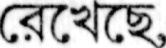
রেখেছে,
